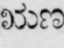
ಋಣ
